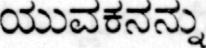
ಯುವಕನನ್ನು
